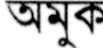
অমুক
